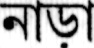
নাড়া
